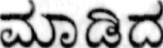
ಮಾಡಿದ
